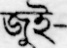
জুই-
